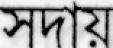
সদায়
